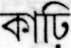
কাঢ়ি
